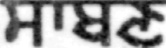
ਸਾਬਣ
